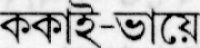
ককাই-ভায়ে
